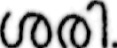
ശരി.
